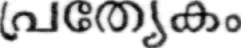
പ്രത്യേകം
